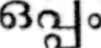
ഒപ്പം
